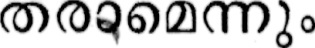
തരാമെന്നും
